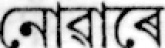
নোৱাৰে
